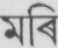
মৰি
